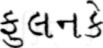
ફુલનકે
